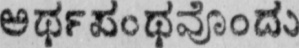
ಅರ್ಥಪಂಥವೊಂದು
